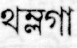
থম্লগা
